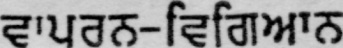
ਵਾਪਰਨ-ਵਿਗਿਆਨ
